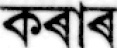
কৰাৰ
